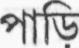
পাড়ি
